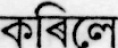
কৰিলে
